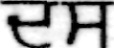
ਦਸ
